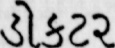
ડોકટર
